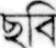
ছবি
